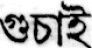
গুচাই
